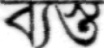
ব্যস্ত
